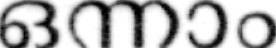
ഒന്നാം
